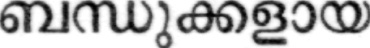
ബന്ധുക്കളായ
